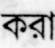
করা
